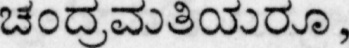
ಚಂದ್ರಮತಿಯರೂ,
